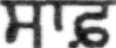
ਸਾਫ਼
